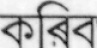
কৰিব
